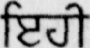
ਇਹੀ
